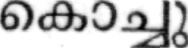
കൊച്ചു
